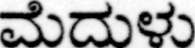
ಮೆದುಳು
